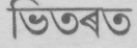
ভিতৰত
